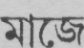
মাজে
